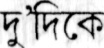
দু'দিকে
